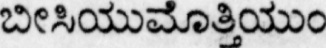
ಬೀಸಿಯುಮೊತ್ತಿಯುಂ
